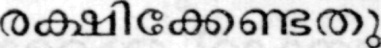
രക്ഷിക്കേണ്ടതു
